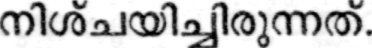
നിശ്ചയിച്ചിരുന്നത്.
